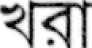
খরা
